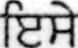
ਇਸੇ
